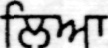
ਲਿਆ
